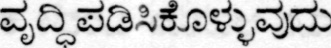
ವೃದ್ಧಿಪಡಿಸಿಕೊಳ್ಳುವುದು
